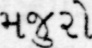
મજુરો
